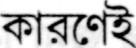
কারণেই
